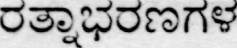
ರತ್ನಾಭರಣಗಳ
